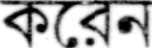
করেন
